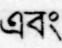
এবং
